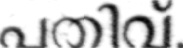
പതിവ്.
